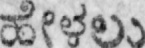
ಹೇಳಲು
